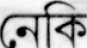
নেকি
